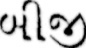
બીજી
